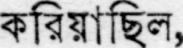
করিয়াছিল,
